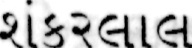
શંકરલાલ
